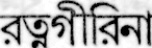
রত্নগীরিনা
